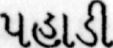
પહાડી
